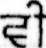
ਵੀ
